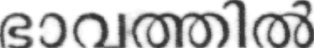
ഭാവത്തില്‍
